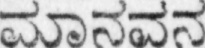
ಮಾನವನ
